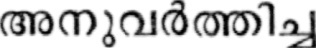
അനുവര്‍ത്തിച്ച
